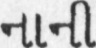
નાની
